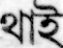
থাই
